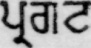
ਪ੍ਰਗਟ
